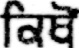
ਕਿਥੋਂ
